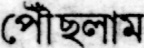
পৌঁছলাম
